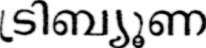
ട്രിബ്യൂണ
